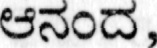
ಆನಂದ,
